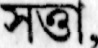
সত্তা,
